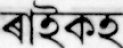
ৰাইকহ
